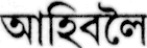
আহিবলৈ
